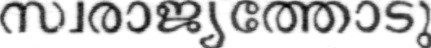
സ്വരാജ്യത്തോടു
